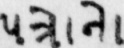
પત્રોનો
